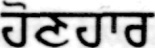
ਹੋਣਹਾਰ
